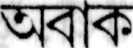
অবাক
